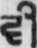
ਵੀ
